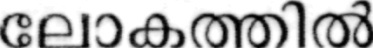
ലോകത്തില്‍
